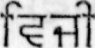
ਵਿਜੀ
